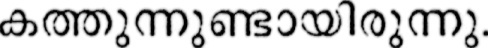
കത്തുന്നുണ്ടായിരുന്നു.
